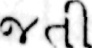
જતી
